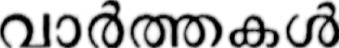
വാര്‍ത്തകള്‍
